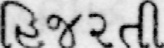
હિજરતી
